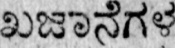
ಖಜಾನೆಗಳ
